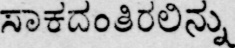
ಸಾಕದಂತಿರಲಿನ್ನು
